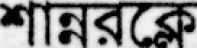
শান্নরক্লে
